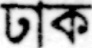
ঢাক
